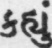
કહ્યું
